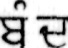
ਬੰਦ
